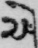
એ
